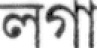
লগা
